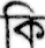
কি
